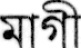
মাগী
